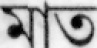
মাত
